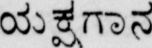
ಯಕ್ಷಗಾನ
